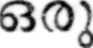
ഒരു
